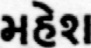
મહેશ
